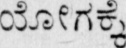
ಯೋಗಕ್ಕೆ
